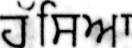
ਹੱਸਿਆ
